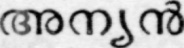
അന്യന്‍
